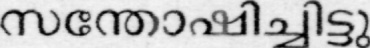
സന്തോഷിച്ചിട്ടു
